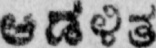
ಅಡಳಿತ
